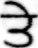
ਤੇ
